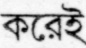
করেই
